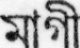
মাগী
